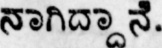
ನಾಗಿದ್ದಾನೆ.
